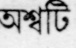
অশ্বটি
